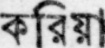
করিয়া
